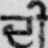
ਦੀ
